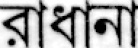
রাধানা
